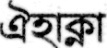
ঐহাক্না
